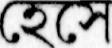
হেসে
